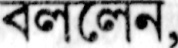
বললেন,
